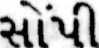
સોંપી
